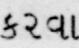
કરવા
